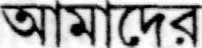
আমাদের
